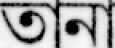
তানা
